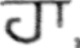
ਹਾਂ,
